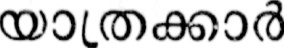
യാത്രക്കാര്‍
